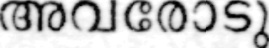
അവരോടു
